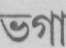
ভগা
